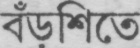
বঁড়শিতে
